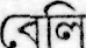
বেলি
